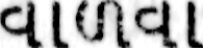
વાળવા
